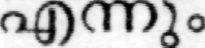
എന്നും
